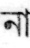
না
